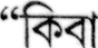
"কিবা
